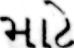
માટે
